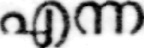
എന്ന
